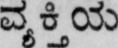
ವ್ಯಕ್ತಿಯ
